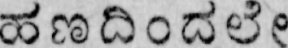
ಹಣದಿಂದಲೇ
